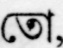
তো,
